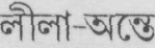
লীলা-অন্তে
